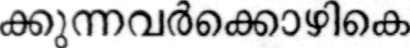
ക്കുന്നവര്‍ക്കൊഴികെ
